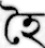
হৈ
